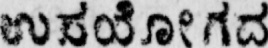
ಉಪಯೋಗದ
